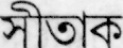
সীতাক
